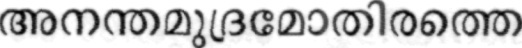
അനന്തമുദ്രമോതിരത്തെ
